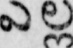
ಎಲ್ಲ
